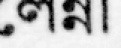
লেন্না
